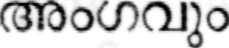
അംഗവും
